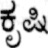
ಕೃಷಿ
